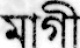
মাগী
